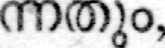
ന്നതും,
